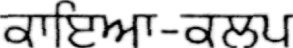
ਕਾਇਆ-ਕਲਪ
